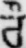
ਰੌ
